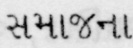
સમાજના
